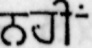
ਨਹੀਂ
